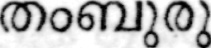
തംബുരു
